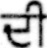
ਦੀ
